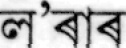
ল'ৰাৰ
